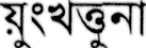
য়ুংখত্তুনা
